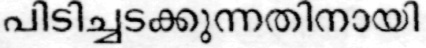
പിടിച്ചടക്കുന്നതിനായി
